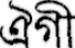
ঐগী
